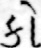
કો
